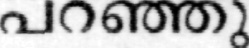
പറഞ്ഞു
